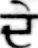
ਦੇ
